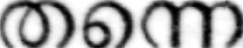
തന്നെ
